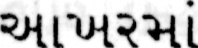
આખરમાં
